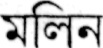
মলিন
